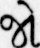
જો
